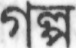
গল্প
